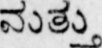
ಮತ್ತು
